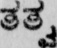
ತತ್ವ
